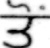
ਤੋਂ
